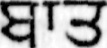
ਬਾਤ
